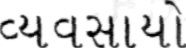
વ્યવસાયો
